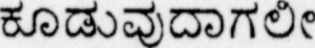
ಕೂಡುವುದಾಗಲೀ
